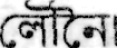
লৌনৈ।
